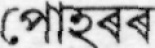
পোহৰৰ
